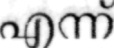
എന്ന്
